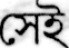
সেই
